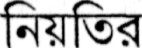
নিয়তির
